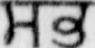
ਸਭ
